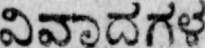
ವಿವಾದಗಳ
